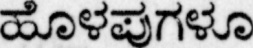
ಹೊಳಪುಗಳೂ
